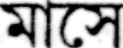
মাসে
